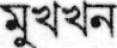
মুখখন
